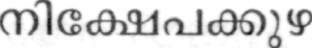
നിക്ഷേപക്കുഴ
